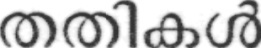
തതികള്‍
